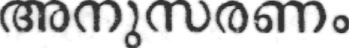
അനുസരണം
